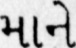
માને
